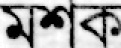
মশক
